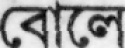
বোলে
